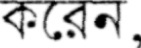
করেন,
